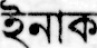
ইনাক
